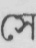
সে
